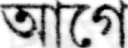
আগে
